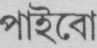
পাইবো
